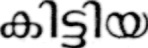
കിട്ടിയ
